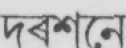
দৰশনে
